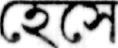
হেসে
